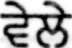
ਵੇਲੇ
